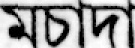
মচাদা
